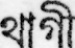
থাগী
